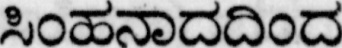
ಸಿಂಹನಾದದಿಂದ
